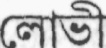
লোভী
